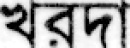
খরদা
